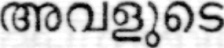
അവളുടെ
